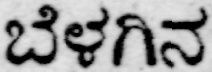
ಬೆಳಗಿನ
